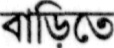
বাড়িতে
